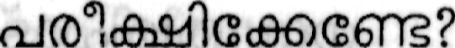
പരീക്ഷിക്കേണ്ടേ?
